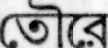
তৌরে
